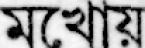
মখোয়
